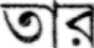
তার
